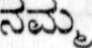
ನಮ್ಮ
